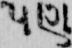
પણ
